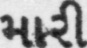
મારી
